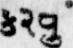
કરવું
